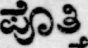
ಪೊತ್ತಿ
